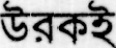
উরকই
